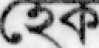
হেক
